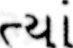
ત્યાં
